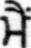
ਮੈਂ
